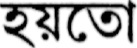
হয়তো
